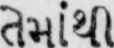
તેમાંથી
